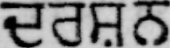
ਦਰਸ਼ਨ
